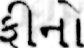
ફીનો
